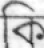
কি
